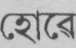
হোৱে
